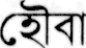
হৌবা
